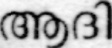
ആദി
